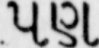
પણ
